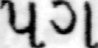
પગ
